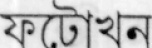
ফটোখন
